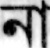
না
